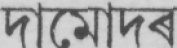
দামোদৰ
